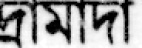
দ্রামাদা
